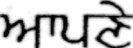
ਆਪਣੇ
